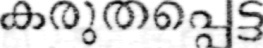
കരുതപ്പെട്ട
